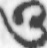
ও
